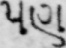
પણ
